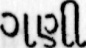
ગણી
